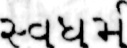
સ્વધર્મ
